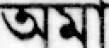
অমা
